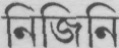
নিজিনি
